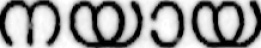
നയായ
